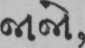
જાજો,
